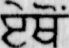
ਏਥੋਂ
